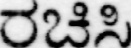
ರಚಿಸಿ
